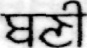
ਬਣੀ
